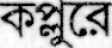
কপ্লুরে
